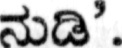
ನುಡಿ’.
